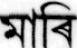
মাৰি
